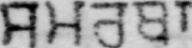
ਸਮਰਥਾ
